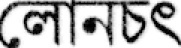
লোনচৎ
